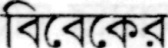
বিবেকের
